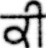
ਕੀ
